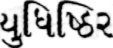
યુધિષ્ઠિર
